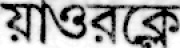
য়াওরক্লে
